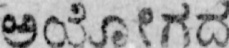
ಆಯೋಗದ
